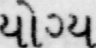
યોગ્ય
